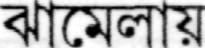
ঝামেলায়
